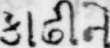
કાઢીને
